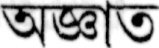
অজ্ঞাত
